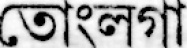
তোংলগা
